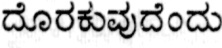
ದೊರಕುವುದೆಂದು
